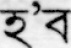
হ'ব
